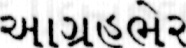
આગ્રહભેર
